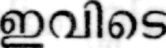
ഇവിടെ
